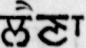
ਲੈਣਾ
